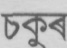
চকুৰ
